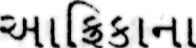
આફ્રિકાના
